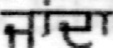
ਜਾਂਦਾ
